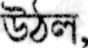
উঠল,
